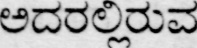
ಅದರಲ್ಲಿರುವ
